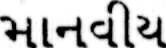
માનવીય
